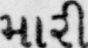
મારી
